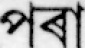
পৰা
